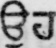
ਉਹ
